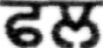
ਫਲ
